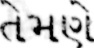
તેમણે
